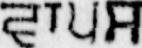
ਵਾਪਸ
